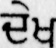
ਦੇਖ
